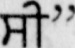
ਸੀ''
